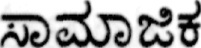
ಸಾಮಾಜಿಕ
